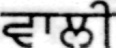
ਵਾਲੀ
